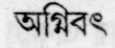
অগ্নিবত্
